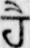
ਹੈ
